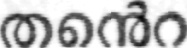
തന്റെ
